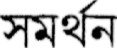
সমর্থন
